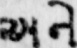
અને
